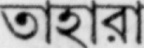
তাহারা
